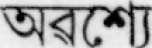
অৱশ্যে
